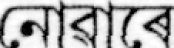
নোৱাৰে
